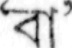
‘বা’
